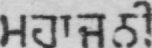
ਮਹਾਜਨੀ
